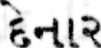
દેનાર
